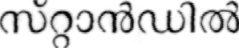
സ്റ്റാന്‍ഡില്‍
